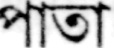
পাতা
